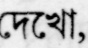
দেখো,
